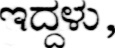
ಇದ್ದಳು,
